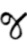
જ
